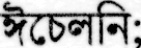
ঈচেলনি;
